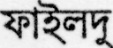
ফাইলদু
